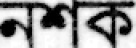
নশক
